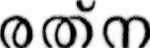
രത്ന
